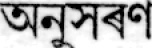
অনুসৰণ
